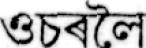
ওচৰলৈ
